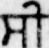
ਸੀ
